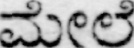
ಮೇಲೆ
